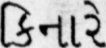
કિનારે
